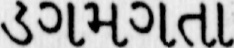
ડગમગતા
